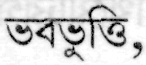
ভবভুত্তি,
